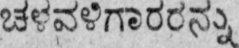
ಚಳವಳಿಗಾರರನ್ನು
